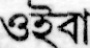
ওইবা
